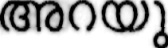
അറയു
